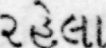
રહેલા
